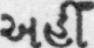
અહીં
